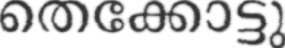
തെക്കോട്ടു
